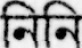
নিনি
